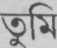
তুমি
